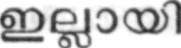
ഇല്ലായി
